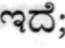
ಇದೆ;
